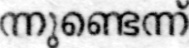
ന്നുണ്ടെന്ന്
